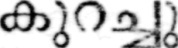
കുറച്ചു
